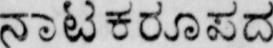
ನಾಟಕರೂಪದ
